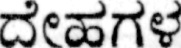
ದೇಹಗಳ
